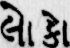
લોકો
